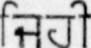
ਜਿਹੀ
